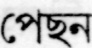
পেছন
